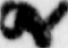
જ
